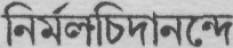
নিৰ্মলচিদানন্দে
